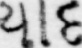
યાદ
